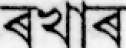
ৰখাৰ
